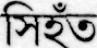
সিহঁত
